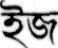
ইজ
